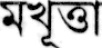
মখূত্তা
